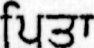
ਪਿਤਾ
